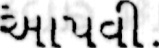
આપવી.
